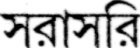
সরাসরি
